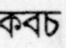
কবচ
